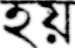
হয়
